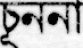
চূননা
